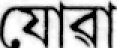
যোৱা
